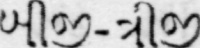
બીજી-ત્રીજી
